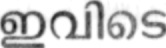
ഇവിടെ
